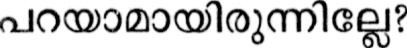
പറയാമായിരുന്നില്ലേ?
